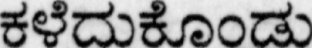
ಕಳೆದುಕೊಂಡು
